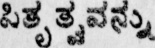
ಪಿತೃತ್ವವನ್ನು
